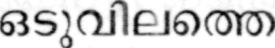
ഒടുവിലത്തെ
